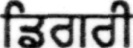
ਡਿਗਰੀ
